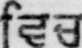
ਵਿਚ
